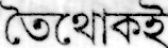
তৈথোকই
